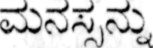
ಮನಸ್ಸನ್ನು
